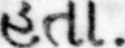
હતા.
